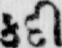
કદી
